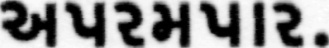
અપરમપાર.
